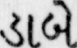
ડાબે
